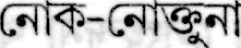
নোক-নোক্তুনা
